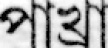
পাখ্রা
